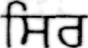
ਸਿਰ
